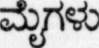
ಮೈಗಳು
